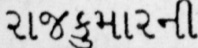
રાજકુમારની
